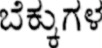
ಬೆಕ್ಕುಗಳ
